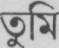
তুমি
